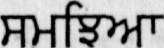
ਸਮਝਿਆ
